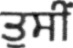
ਤੁਸੀਂ
